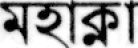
মহাক্না
